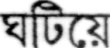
ঘটিয়ে
